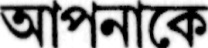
আপনাকে
